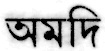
অমদি
